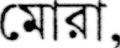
মোরা,
